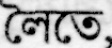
লৈতে,
